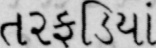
તરફડિયાં
